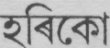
হৰিকো
